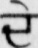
ਦੇ
